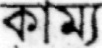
কাম্য
